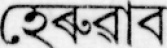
হেৰুৱাব
